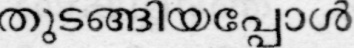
തുടങ്ങിയപ്പോള്‍
